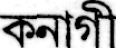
কনাগী
